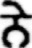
ਨੇ
